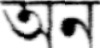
অন
